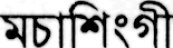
মচাশিংগী
